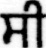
ਸੀ
